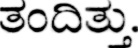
ತಂದಿತ್ತು.
